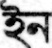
ইন
